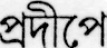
প্ৰদীপে
